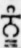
ਨੂੰ
